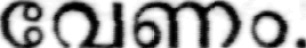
വേണം.
